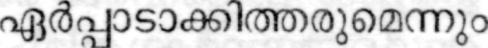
ഏര്‍പ്പാടാക്കിത്തരുമെന്നും
